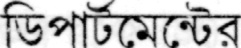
ডিপার্টমেন্টের
